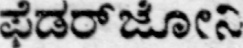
ಫೆಡರ್‌ಜೋನಿ
